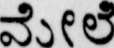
ಮೇಲೆ
